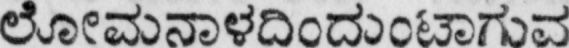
ಲೋಮನಾಳದಿಂದುಂಟಾಗುವ
